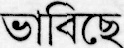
ভাবিছে
